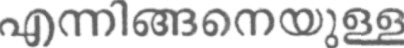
എന്നിങ്ങനെയുള്ള
